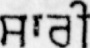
ਸਾਰੀ
